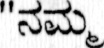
“ನಮ್ಮ
